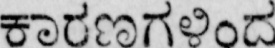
ಕಾರಣಗಳಿಂದ
